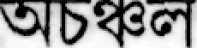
অচঞ্চল
